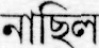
নাছিল
